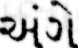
અંગે
